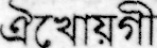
ঐখোয়গী
